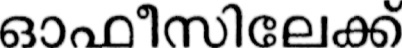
ഓഫീസിലേക്ക്
